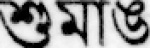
শুমাঙ
